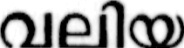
വലിയ
